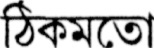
ঠিকমতো
